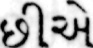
છીએ
